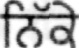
ਨਿੱਕੇ
